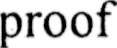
proof
